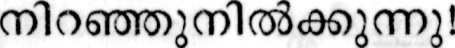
നിറഞ്ഞുനില്‍ക്കുന്നു!
